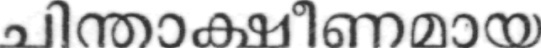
ചിന്താക്ഷീണമായ
